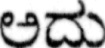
ಅದು
